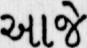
આજે
